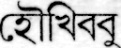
হৌখিববু
